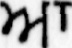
ਆ
